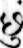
છું
